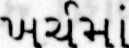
ખર્ચમાં
